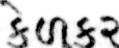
કેળકર
